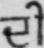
ਦੀ
